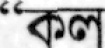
"কল
